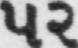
પર
